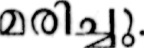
മരിച്ചു.
